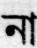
না
